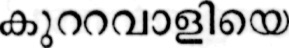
കുററവാളിയെ
